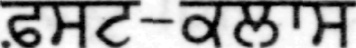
ਫ਼ਸਟ-ਕਲਾਸ
